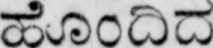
ಹೊಂದಿದ
